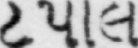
ટાપાલ
